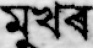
মুখৰ
